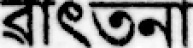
ৱাৎতনা
